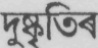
দুষ্কৃতিৰ
